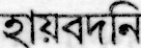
হায়বদনি
